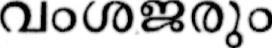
വംശജരും
